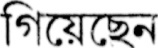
গিয়েছেন
